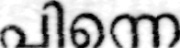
പിന്നെ
